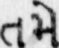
તમે
